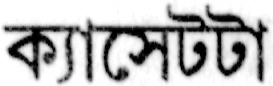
ক্যাসেটটা
